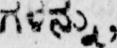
ಗಳನ್ನು,
